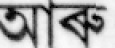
আৰু
